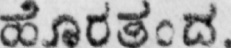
ಹೊರತಂದ.
